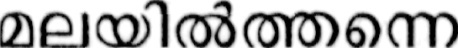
മലയില്‍ത്തന്നെ
